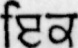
ਇਕ
